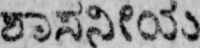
ಶಾಸನೀಯ
